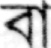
বা
